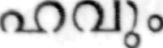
ഹവും
